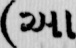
(આ
